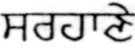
ਸਰਹਾਣੇ
